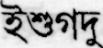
ইশুগদু
